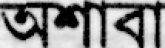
অশাবা
